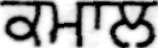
ਕਮਾਲ
